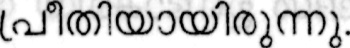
പ്രീതിയായിരുന്നു.
